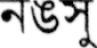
নঙসু
